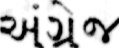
અંગ્રેજ
